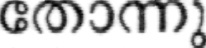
തോന്നു
